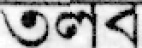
তলব
